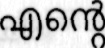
എന്റെ
